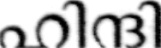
ഹിന്ദി
